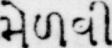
મેળવી
